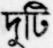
দুটি
